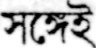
সঙ্গেই
